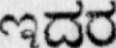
ಇದರ
